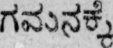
ಗಮನಕ್ಕೆ
